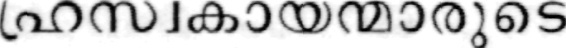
ഹ്രസ്വകായന്മാരുടെ
